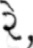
રે,
